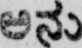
ಅನು
